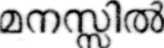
മനസ്സില്‍
